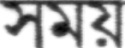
সময়
